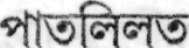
পাতলিলত
